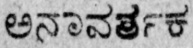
ಅನಾವರ್ತಕ
